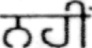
ਨਹੀਂ
